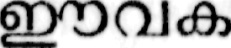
ഈവക
